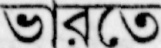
ভারতে
